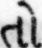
તો
